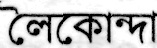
লৈকোন্দা
